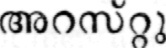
അറസ്റ്റു
